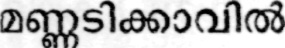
മണ്ണടിക്കാവില്‍
